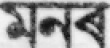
মনৰ
